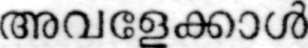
അവളേക്കാള്‍
